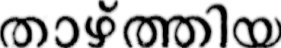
താഴ്ത്തിയ
